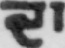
ਦਾ
